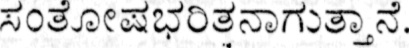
ಸಂತೋಷಭರಿತನಾಗುತ್ತಾನೆ.
